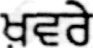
ਖ਼ਵਰੇ
